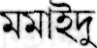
মমাইদু
